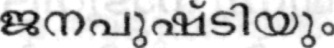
ജനപുഷ്ടിയും
